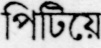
পিটিয়ে
